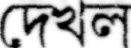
দেখল
